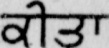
ਕੀਤਾ
